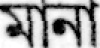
মানা
